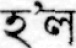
হ'ল
